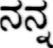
ನನ್ನ
